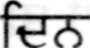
ਦਿਨ
